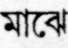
মাঝে
